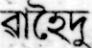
ৱাহৈদু
